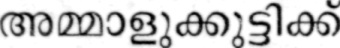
അമ്മാളുക്കുട്ടിക്ക്
